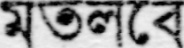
মতলবে
